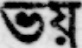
ভয়
